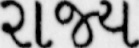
રાજ્ય
